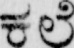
ಕಲೆ
